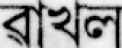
ৱাখল
